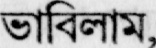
ভাবিলাম,
